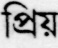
প্রিয়
